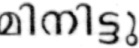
മിനിട്ടു
